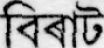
বিৰাট
